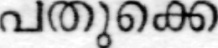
പതുക്കെ
